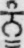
ਨੂੰ
